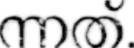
ന്നത്.
